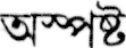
অস্পষ্ট
